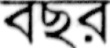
বছর
